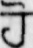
ਹੋ
